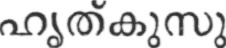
ഹൃത്കുസു
